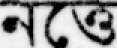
নত্তে
